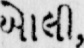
બોલી,
